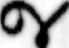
જ
